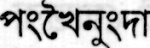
পংখৈনুংদা
